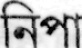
নিপা
